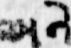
અને
